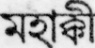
মহাক্কী
